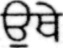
ਉਥੇ
